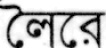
লৈরে
